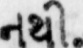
નથી.
